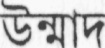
উন্মাদ
